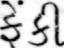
ફેંકી
